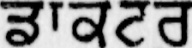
ਡਾਕਟਰ
